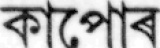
কাপোৰ
